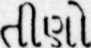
તીણો
